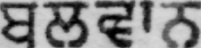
ਬਲਵਾਨ
